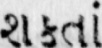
શકતાં
